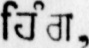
ਹਿੰਗ,
